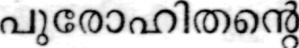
പുരോഹിതന്റെ
